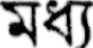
মধ্য
